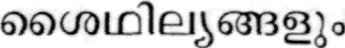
ശൈഥില്യങ്ങളും
